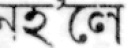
নহ'লে
